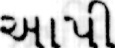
આપી
